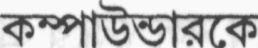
কম্পাউন্ডারকে
